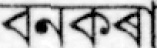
বনকৰা
